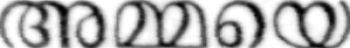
അമ്മയെ
